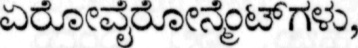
ಏರೋವೈರೋನ್ಮೆಂಟ್‌ಗಳು,
